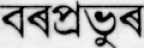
বৰপ্রভুৰ
